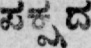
ಪಕ್ಷದ
